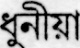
ধুনীয়া
